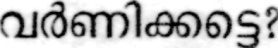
വര്‍ണിക്കട്ടെ?
